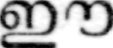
ഈ
